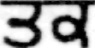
ਤਕ
